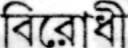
বিরোধী
